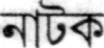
নাটক
